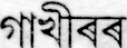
গাখীৰৰ
